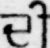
ਦੀ
